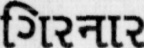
ગિરનાર
